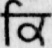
ਕਿ
